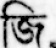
জি.
